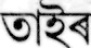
তাইৰ
